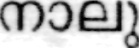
നാലു
